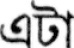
এটা
